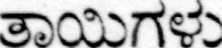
ತಾಯಿಗಳು
